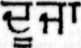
ਦੂਜਾ
